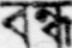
বন্ধ
